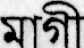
মাগী
